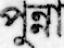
পুন্না
